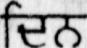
ਦਿਨ
